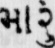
મારું
